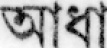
আধা
